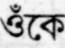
ওঁকে
